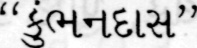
"કુંભનદાસ"
